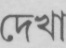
দেখা
